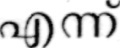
എന്ന്
